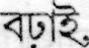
বঢ়াই,
